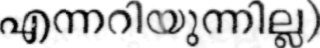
എന്നറിയുന്നില്ല)
